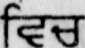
ਵਿਚ
